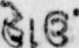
હોઉં
